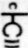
ਨੂੰ
